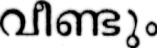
വീണ്ടും
